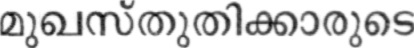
മുഖസ്തുതിക്കാരുടെ
